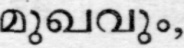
മുഖവും,
